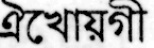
ঐখোয়গী
